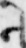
ને
